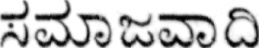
ಸಮಾಜವಾದಿ
